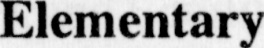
Elementary
